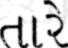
તારે
